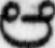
ಆ
